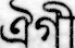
ঐগী
